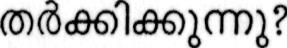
തര്‍ക്കിക്കുന്നു?
